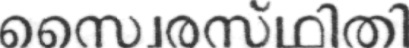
സ്വൈരസ്ഥിതി
